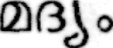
മദ്യം
